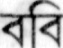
ববি
